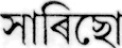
সাৰিছো
